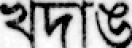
খদাঙ
